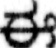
ಈ
